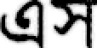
এস
